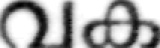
വക
